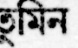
তুমিন
